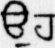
ਉਹ
